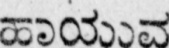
ಹಾಯುವ
